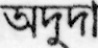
অদুদা
